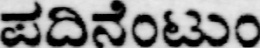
ಪದಿನೆಂಟುಂ
